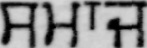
ਸਮਾਜ
